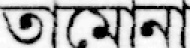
তামোনা
